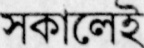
সকালেই
